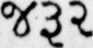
જરૂર
